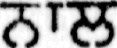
ਨਾਲ
